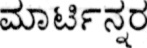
ಮಾರ್ಟಿನ್ನರ
